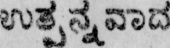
ಉತ್ಪನ್ನವಾದ
